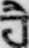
ਹੈ
